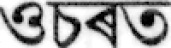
ওচৰত
